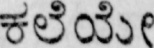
ಕಲೆಯೇ
